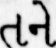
તને
